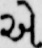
એ
